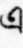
এ
